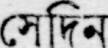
সেদিন
